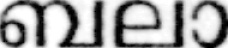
ബലാ
